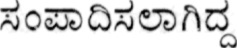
ಸಂಪಾದಿಸಲಾಗಿದ್ದ
